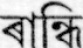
ৰান্ধি
